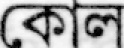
কোল
